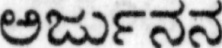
ಅರ್ಜುನನ
